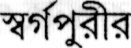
স্বর্গপুরীর
